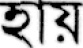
হায়
